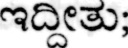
ಇದ್ದೀತು;
